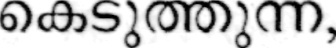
കെടുത്തുന്ന,
